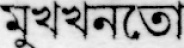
মুখখনতো
